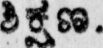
ಶಿಕ್ಷಣ.
